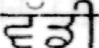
ਵੱਡੀ
